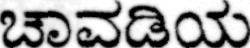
ಚಾವಡಿಯ
